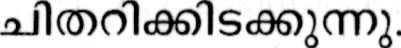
ചിതറിക്കിടക്കുന്നു.
